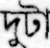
দুটা
